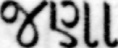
જણા
